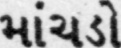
માંચડો
